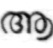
ആ
